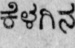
ಕೆಳಗಿನ
